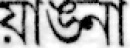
য়াঙনা
